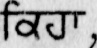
ਕਿਹਾ,
